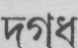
দগধ
